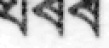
ঘৰৰ
